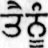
ਤੈਨੂੰ
